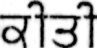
ਕੀਤੀ
